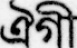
ঐগী
